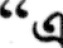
“এ
